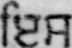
ਇਸ
